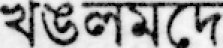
খঙলমদে
